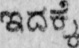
ಇದಕ್ಕೆ
